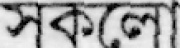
সকলো
